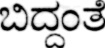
ಬಿದ್ದಂತೆ
